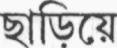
ছাড়িয়ে
